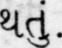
થતું.
